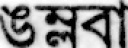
ঙম্লবা
